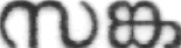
സങ്ക
